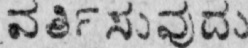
ವರ್ತಿಸುವುದು
